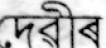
দেৱীৰ
